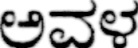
ಅವಳ
